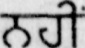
ਨਹੀਂ
